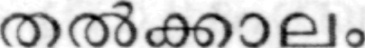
തല്‍ക്കാലം
